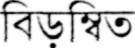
বিড়ম্বিত
